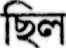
ছিল
